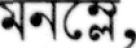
মনম্লে,
